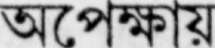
অপেক্ষায়
